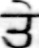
ਤੇ
